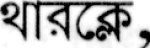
থারক্লে,
